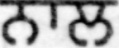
ਨਾਲ
